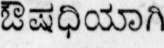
ಔಷಧಿಯಾಗಿ
